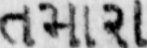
તમારા
